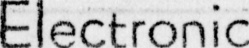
Electronic
